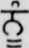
ਨੂੰ
